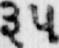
રૂપ
